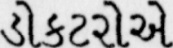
ડોકટરોએ
